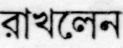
রাখলেন
